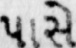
પાસે
